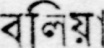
বলিয়া
